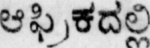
ಆಫ್ರಿಕದಲ್ಲಿ
